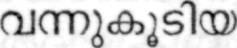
വന്നുകൂടിയ
